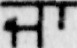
ਜਾ
